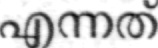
എന്നത്
